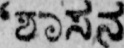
‘ಶಾಸನ
